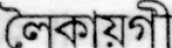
লৈকায়গী
